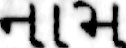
નામ
